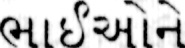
ભાઈઓને
